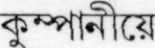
কুম্পানীয়ে
